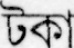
টকা
